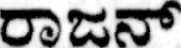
ರಾಜನ್
